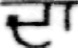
ਦਾ
